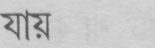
যায়
